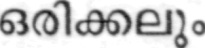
ഒരിക്കലും
